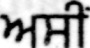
ਅਸੀਂ
